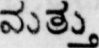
ಮತ್ತು
